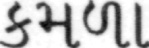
કમળા
